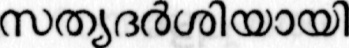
സത്യദര്‍ശിയായി
